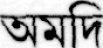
অমদি
